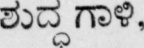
ಶುದ್ಧಗಾಳಿ,
